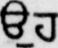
ਉਹ
